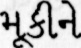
મૂકીને
